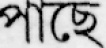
পাছে
